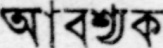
আবশ্যক
